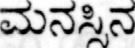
ಮನಸ್ಸಿನ
